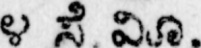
೪ಸೆ.ಮೀ.
